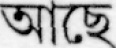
আছে
